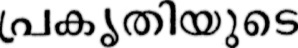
പ്രകൃതിയുടെ
